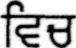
ਵਿਚ
